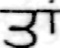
ਤਾਂ
